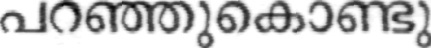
പറഞ്ഞുകൊണ്ടു
